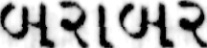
બરાબર
